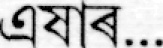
এষাৰ...
